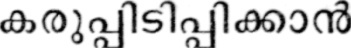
കരുപ്പിടിപ്പിക്കാന്‍
